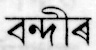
বন্দীৰ
